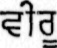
ਵੀਰੂ
